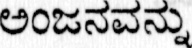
ಅಂಜನವನ್ನು
